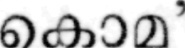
കൊമ'
